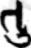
તુ
